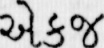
એકજ
